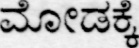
ಮೋಡಕ್ಕೆ
